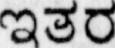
ಇತರ
